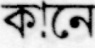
কানে
